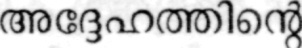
അദ്ദേഹത്തിന്റെ
